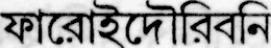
ফারোইদৌরিবনি
